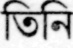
তিনি
